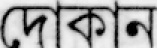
দোকান
